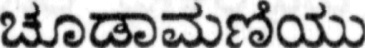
ಚೂಡಾಮಣಿಯು
